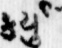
કર્યું
